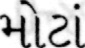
મોટાં
